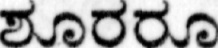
ಶೂರರೂ
